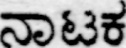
ನಾಟಕ
